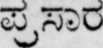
ಪ್ರಸಾರ
